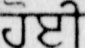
ਹੋਈ
